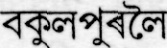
বকুলপুৰলৈ
